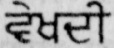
ਵੇਖਦੀ
